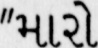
"મારો
